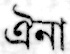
ঐনা
